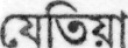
যেতিয়া
